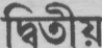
দ্বিতীয়
